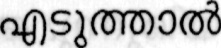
എടുത്താല്‍
